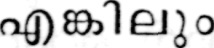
എങ്കിലും
